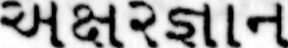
અક્ષરજ્ઞાન
